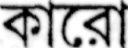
কারো
